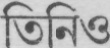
তিনিও
